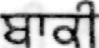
ਬਾਕੀ
